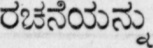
ರಚನೆಯನ್ನು
